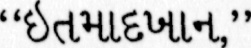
"ઇતમાદખાન,"
